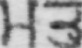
ਮਤ
